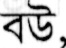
বউ,
